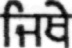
ਜਿਥੇ
